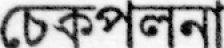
চেকপলনা
